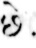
છે.
